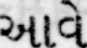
આવે
